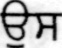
ਉਸ
